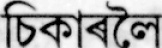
চিকাৰলৈ
